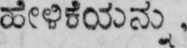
ಹೇಳಿಕೆಯನ್ನು,
